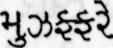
મુઝફ્ફરે
